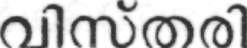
വിസ്തരി
